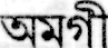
অমগী
